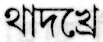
থাদখ্রে
